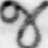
જ
